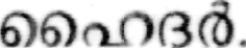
ഹൈദര്‍.
